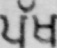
ਪੱਖ
